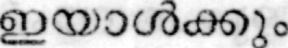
ഇയാള്‍ക്കും
